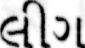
લીગ
